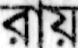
রায়
